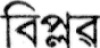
বিপ্লৱ
